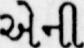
એની
